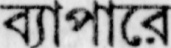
ব্যাপারে
